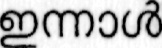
ഇന്നാള്‍
